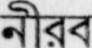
নীরব
